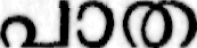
പാത
